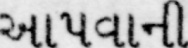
આપવાની
